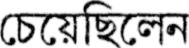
চেয়েছিলেন
